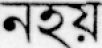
নহয়
